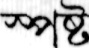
স্পষ্ট
